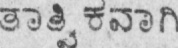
ತಾತ್ವಿಕವಾಗಿ
